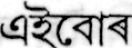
এইবোৰ
